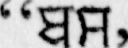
''ਬਸ,
